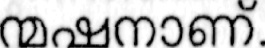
ന്മഷനാണ്.
